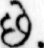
છે.
